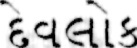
દેવલોક
